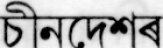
চীনদেশৰ
